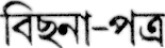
বিছনা-পত্র
